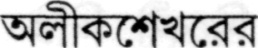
অলীকশেখরের
